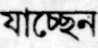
যাচ্ছেন
